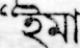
“ইমা
